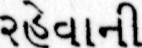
રહેવાની
